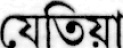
যেতিয়া
